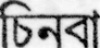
চিনবা
